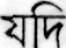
যদি
